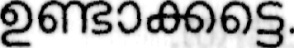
ഉണ്ടാക്കട്ടെ.
